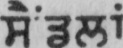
ਸੈਂਡਲਾਂ
